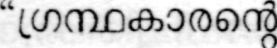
"ഗ്രന്ഥകാരന്റെ
